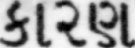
કારણ
